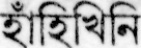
হাঁহিখিনি
